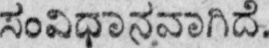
ಸಂವಿಧಾನವಾಗಿದೆ.
